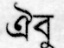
ঐবু
